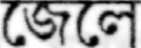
জেলে
